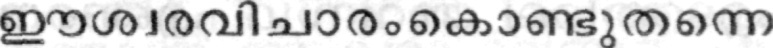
ഈശ്വരവിചാരംകൊണ്ടുതന്നെ
